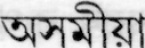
অসমীয়া
